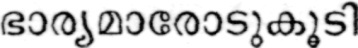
ഭാര്യമാരോടുകൂടി
